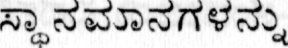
ಸ್ಥಾನಮಾನಗಳನ್ನು
